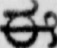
ಈ
